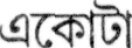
একোটা
